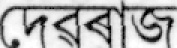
দেৱৰাজ
